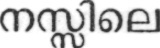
നസ്സിലെ
